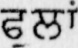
ਫੁਲਾਂ
